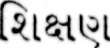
શિક્ષણ
